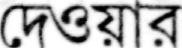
দেওয়ার
